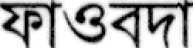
ফাওবদা
